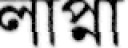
লাপ্না
